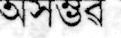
অসম্ভৱ
